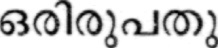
ഒരിരുപതു
